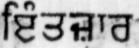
ਇੰਤਜ਼ਾਰ
